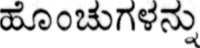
ಹೊಂಚುಗಳನ್ನು
